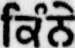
ਕਿੰਨੇ
